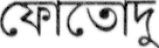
ফোতোদু
